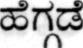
ಹೆಗ್ಗಡೆ
